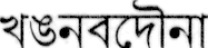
খঙনবদৌনা
